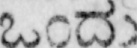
ಒಂದು
